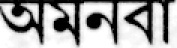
অমনবা
